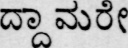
ದ್ದಾಮರೇ
